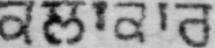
ਕਲਾਕਾਰ
